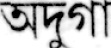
অদুগা
